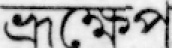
ভ্ৰূক্ষেপ
